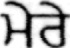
ਮੇਰੇ
